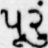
પૂરું
